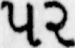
પર
